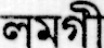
লমগী
